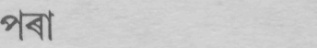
পৰা
